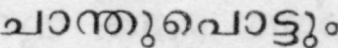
ചാന്തുപൊട്ടും
